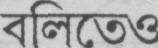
বলিতেও
